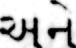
અને
